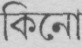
কিনো
